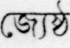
জ্যেষ্ঠ
